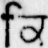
ਕਿ
